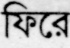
ফিরে
